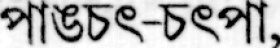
পাঙচৎ-চৎপা,
